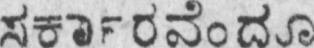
ಸರ್ಕಾರವೆಂದೂ
